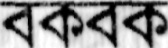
বকবক
